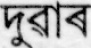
দুৱাৰ
